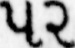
પર
